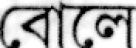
বোলে
